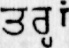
ਤਰ੍ਹਾਂ
